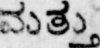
ಮತ್ತು
